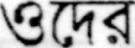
ওদের
